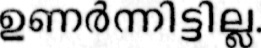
ഉണര്‍ന്നിട്ടില്ല.
